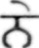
ਨੇ
